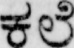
ಕಲೆ
